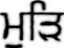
ਮੁੜਿ
